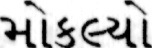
મોકલ્યો
